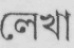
লেখা
